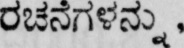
ರಚನೆಗಳನ್ನು,
